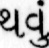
થવું
